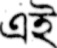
এই
